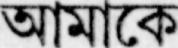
আমাকে
